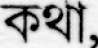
কথা,
